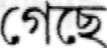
গেছে
